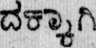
ದಕ್ಕಾಗಿ
